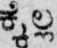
ಕ್ಕೆಲ್ಲ
